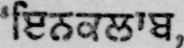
'ਇਨਕਲਾਬ,
